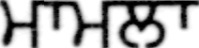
ਮਾਮਲਾ
